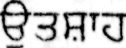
ਉਤਸ਼ਾਹ
